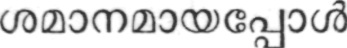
ശമാനമായപ്പോള്‍
